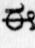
ಈ
